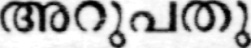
അറുപതു
